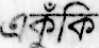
একুঁকি
